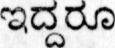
ಇದ್ದರೂ
